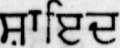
ਸ਼ਾਇਦ
